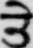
ਤੇ
